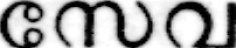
സേവ
